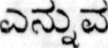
ಎನ್ನುವ
